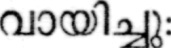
വായിച്ചു:
